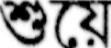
শুয়ে
